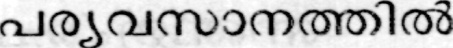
പര്യവസാനത്തില്‍
